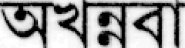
অখন্নবা
